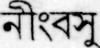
নীংবসু
